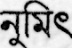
নুমিৎ
